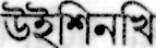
উইশিনখি
